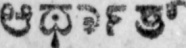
ಆರ್ಥಾತ್
